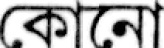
কোনো
